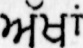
ਅੱਖਾਂ
